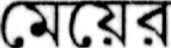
মেয়ের
